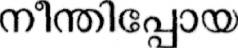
നീന്തിപ്പോയ
